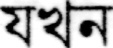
যখন
